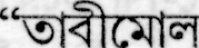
“তাবীমোল
